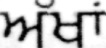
ਅੱਖਾਂ
